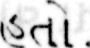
હતો.
